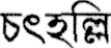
চৎহল্লি
